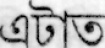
এটাত
